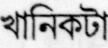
খানিকটা
